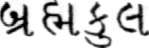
બ્રહ્મકુલ
